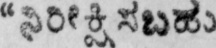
“ನಿರೀಕ್ಷಿಸಬಹು
